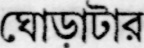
ঘোড়াটার
